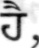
ਹੈ,
